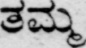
ತಮ್ಮ
